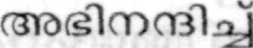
അഭിനന്ദിച്ച്
